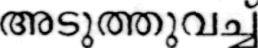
അടുത്തുവച്ച്
